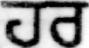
ਹਰ
